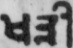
ਖੜੀ
